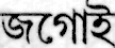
জগোই
